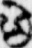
છે
